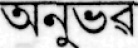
অনুভৱ
